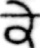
ਕੇ
